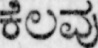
ಕೆಲವು
